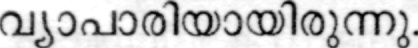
വ്യാപാരിയായിരുന്നു.
